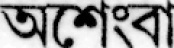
অশেংবা
